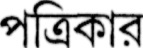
পত্রিকার
